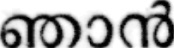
ഞാന്‍
